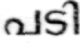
പടി
